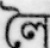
লৈ
